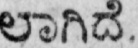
ಲಾಗಿದೆ.
